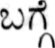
ಬಗ್ಗೆ
